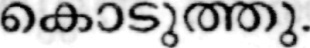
കൊടുത്തു.
